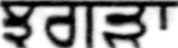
ਝਗੜਾ
